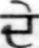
ਦੇ
